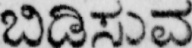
ಬಿಡಿಸುವ
